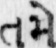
તમે
